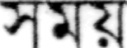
সময়
